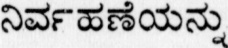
ನಿರ್ವಹಣೆಯನ್ನು
